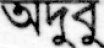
অদুবু
